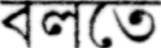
বলতে
